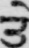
ਤੇ
